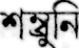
শম্ব্রুনি
